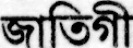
জিতিগী
